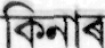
কিনাৰ
